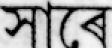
সাৰে
